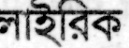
লাইরিক
